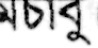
মচাবু
